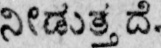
ನೀಡುತ್ತದೆ.
